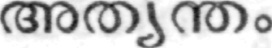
അത്യന്തം
